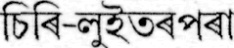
চিৰি-লুইতৰপৰা
